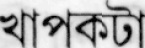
খাপকটা
